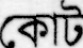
কোট
